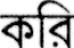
করি
